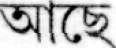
আছে
